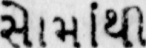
સોમાંથી
